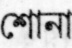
শোনা
